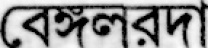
বেঙ্গলরদা
